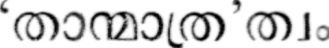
'താന്മാത്ര'ത്വം
